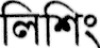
লিশিং
